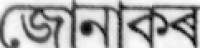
জোনাকৰ
